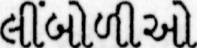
લીંબોળીઓ
